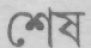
শেষ
